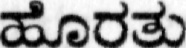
ಹೊರತು
